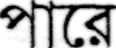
পারে
